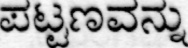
ಪಟ್ಟಣವನ್ನು
